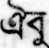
ঐবু
